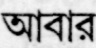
আবার
